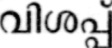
വിശപ്പ്
